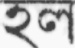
হল
